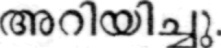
അറിയിച്ചു.
